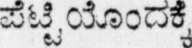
ಪೆಟ್ಟಿಯೊಂದಕ್ಕೆ
